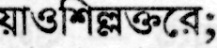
য়াওশিল্লক্তরে;
